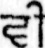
ਵੀ
